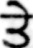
ਤੇ
